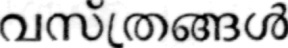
വസ്ത്രങ്ങള്‍
